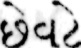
છેવટે
